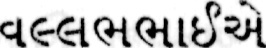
વલ્લભભાઈએ
